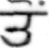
ਤੋਂ
